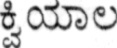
ಕ್ವಿಯಾಲ
